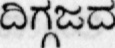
ದಿಗ್ಗಜದ
